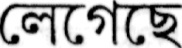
লেগেছে
